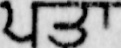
ਪਤਾ
